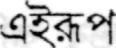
এইরূপ
